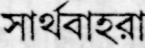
সার্থবাহরা
